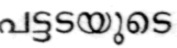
പട്ടടയുടെ
